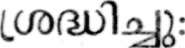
ശ്രദ്ധിച്ചു:
